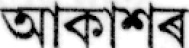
আকাশৰ
